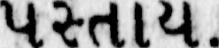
પસ્તાય.
